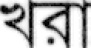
খরা
